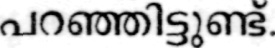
പറഞ്ഞിട്ടുണ്ട്.
